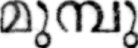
മുമ്പു
